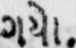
ગયો.
